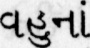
વહુનાં
